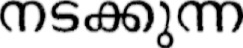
നടക്കുന്ന
